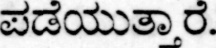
ಪಡೆಯುತ್ತಾರೆ.
